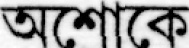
অশোকে
